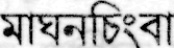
মাঘনচিংবা
